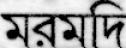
মরমদি
